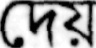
দেয়
